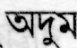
অদুম
